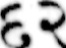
દર
